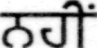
ਨਹੀਂ
